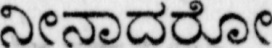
ನೀನಾದರೋ
